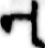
ન
